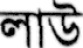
লাউ
